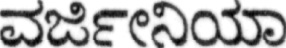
ವರ್ಜೀನಿಯಾ
